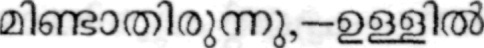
മിണ്ടാതിരുന്നു,-ഉള്ളില്‍
